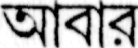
আবার
